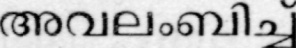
അവലംബിച്ച്
